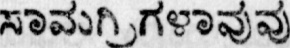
ಸಾಮಗ್ರಿಗಳಾವುವು
